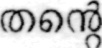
തന്റെ
